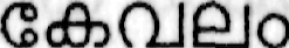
കേവലം
